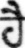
ਹੈ
